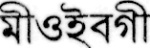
মীওইবগী
